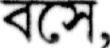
বসে,
